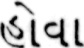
હોવા
